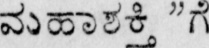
ಮಹಾಶಕ್ತಿ”ಗೆ
